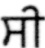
ਸੀ
